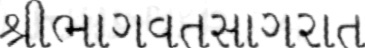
શ્રીભાગવતસાગરાત
